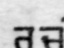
ਰਚੀ
